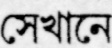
সেখানে
